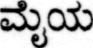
ಮೈಯ
